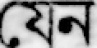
যেন
